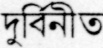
দুর্বিনীত
